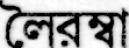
লৈরম্বা
